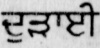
ਦੁੜਾਈ
